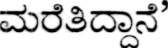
ಮರೆತಿದ್ದಾನೆ'
